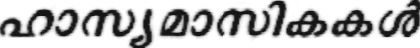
ഹാസ്യമാസികകള്‍
